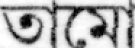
তামো
